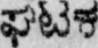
ಘಟಕ
